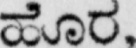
ಹೊರ,
